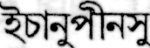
ইচানুপীনসু
